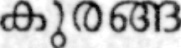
കുരങ്ങ
